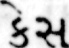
કેસ
